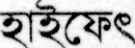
হাইফেৎ
